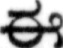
ಈ
